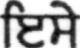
ਇਸੇ
